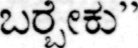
ಬರ್ಬೇಕು"
